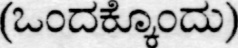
(ಒಂದಕ್ಕೊಂದು)
